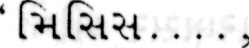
'મિસિસ.....,
